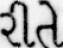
રીતે
